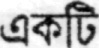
একটি
